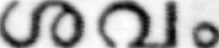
ശവം
